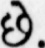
છે.
